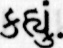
કહ્યું.
